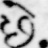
છે.
